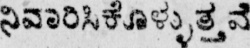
ನಿವಾರಿಸಿಕೊಳ್ಳುತ್ತವೆ
